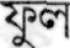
ফুল
